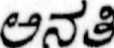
ಅನತಿ
